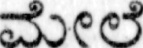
ಮೇಲೆ
